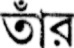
তাঁর
